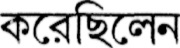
করেছিলেন
